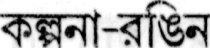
কল্পনা-রঙিন
